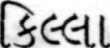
કિલ્લા
